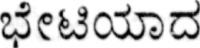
ಭೇಟಿಯಾದ
